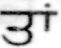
ਤਾਂ
